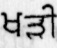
ਖੜੀ
